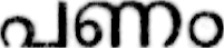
പണം
